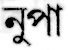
নুপা
